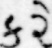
કરે
